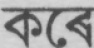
কৰে
